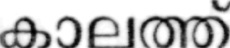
കാലത്ത്
